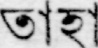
তাহা
